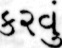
કરવું
